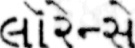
લૉરેન્સે
